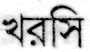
খরসি
